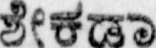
ಶೇಕಡಾ
